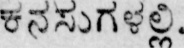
ಕನಸುಗಳಲ್ಲಿ.
